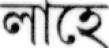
লাহে
